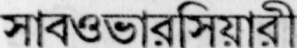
সাবওভারসিয়ারী
